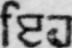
ਇਹ
